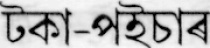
টকা-পইচাৰ
